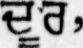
ਦੂਰ,
